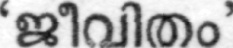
‘ജീവിതം'
